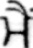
ਮੈਂ
